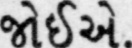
જોઈએ.
